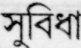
সুবিধা
